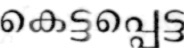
കെട്ടപ്പെട്ട
